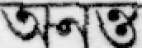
অনন্ত
